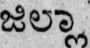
ಜಿಲ್ಲಾ
